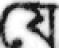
যে
